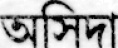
অসিদা
